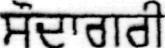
ਸੌਦਾਗਰੀ
